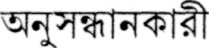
অনুসন্ধানকারী
